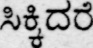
ಸಿಕ್ಕಿದರೆ
